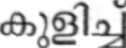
കുളിച്ച്
